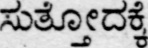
ಸುತ್ತೋದಕ್ಕೆ
